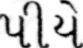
પીયે
